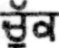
ਚੁੱਕ
